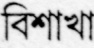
বিশাখা
